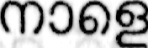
നാളെ
